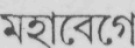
মহাবেগে
